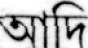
আদি
